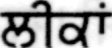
ਲੀਕਾਂ
